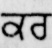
ਕਰ
